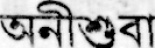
অনীশুবা
